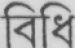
বিধি
